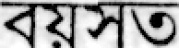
বয়সত
